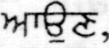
ਆਉਣ,
